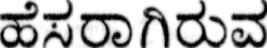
ಹೆಸರಾಗಿರುವ
